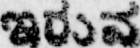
ಇರುವ
